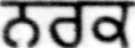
ਨਰਕ
